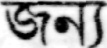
জন্য
